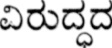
ವಿರುದ್ಧದ
